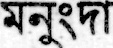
মনুংদা
